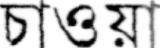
চাওয়া
